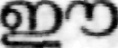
ഈ
